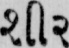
શીર
